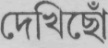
দেখিছোঁ
